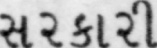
સરકારી
